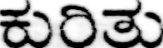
ಕುರಿತು
